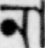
না
